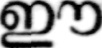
ഈ
